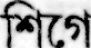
শিগে
